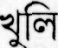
খুলি
